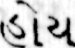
હોય
